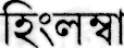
হিংলম্বা
